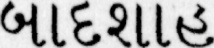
બાદશાહ
